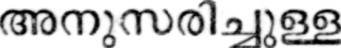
അനുസരിച്ചുള്ള
